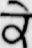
ਕੇ
